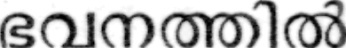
ഭവനത്തില്‍
